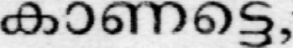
കാണട്ടെ,
